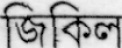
জিকিল
